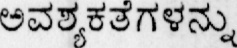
ಅವಶ್ಯಕತೆಗಳನ್ನು
